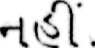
નહીં.
